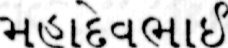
મહાદેવભાઈ
